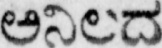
ಅನಿಲದ
